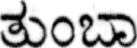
ತುಂಬಾ
